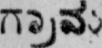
ಗ್ರಾಮ
